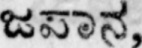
ಜಪಾನ,
